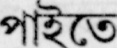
পাইতে
